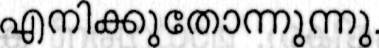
എനിക്കുതോന്നുന്നു.
